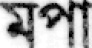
মপা
